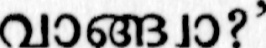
വാങ്ങ്വാ?’
